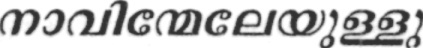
നാവിന്മേലേയുള്ളു
